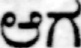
ಆಗ
